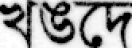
খঙদে
